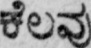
ಕೆಲವು
